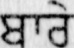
ਬਾਰੇ
